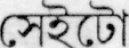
সেইটো
